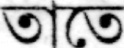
তাতে
